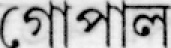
গোপাল
